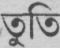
তুতি
